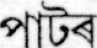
পাটৰ
